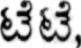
ಟೆಟೆ,
